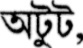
অটুট,
